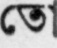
তো
